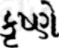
કૃષ્ણ
